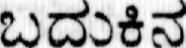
ಬದುಕಿನ
